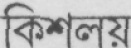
কিশলয়
